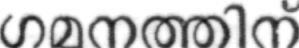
ഗമനത്തിന്
